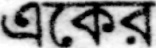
একের
